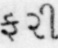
ફરી
